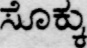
ಸೊಕ್ಕು
